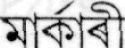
মাৰ্কাৰী
